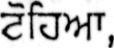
ਟੋਹਿਆ,
